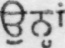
ਉਨ੍ਹਾਂ
